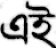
এই
